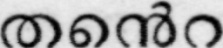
തന്റെ
